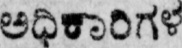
ಅಧಿಕಾರಿಗಳ
